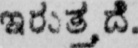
ಇರುತ್ತದೆ.
